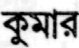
কুমার
